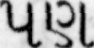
પણ
